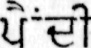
ਪੈਂਦੀ
